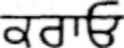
ਕਰਾਓ
